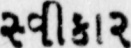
સ્વીકાર
